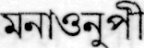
মনাওনুপী
